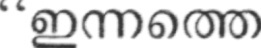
"ഇന്നത്തെ
